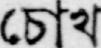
চোখ
